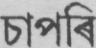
চাপৰি
